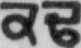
ਕਢ
